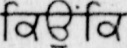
ਕਿਉਂਕਿ
